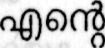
എന്റെ
